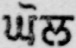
ਘੋਲ
